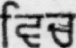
ਵਿਚ
